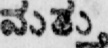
ಮತ್ತು
